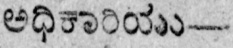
ಅಧಿಕಾರಿಯು-
